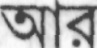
আর
